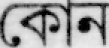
কোন
